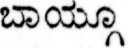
ಬಾಯ್ಗೂ
